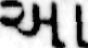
આ
